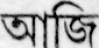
আজি
